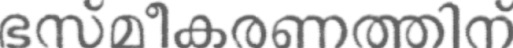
ഭസ്മീകരണത്തിന്
